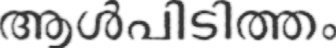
ആള്‍പിടിത്തം
